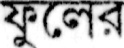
ফুলের
